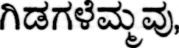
ಗಿಡಗಳೆಮ್ಮವು,
